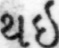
થઈ
